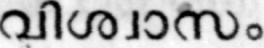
വിശ്വാസം
